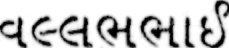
વલ્લભભાઈ
